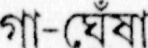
গা-ঘেঁষা
